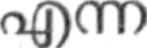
എന്ന
